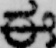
ಈ
